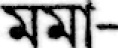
মমা-
